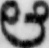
ಆ
